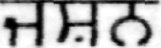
ਜਸ਼ਨ
